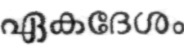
ഏകദേശം
